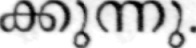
ക്കുന്നു.
